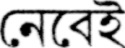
নেবেই
